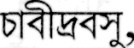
চাবীদ্রবসু,
